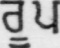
ਰੂਪ
